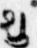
શું
